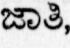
ಜಾತಿ,
